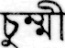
চুম্মী
